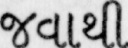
જવાથી
